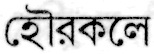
হৌরকলে
